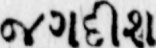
જગદીશ
